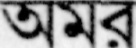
অমর
